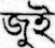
জুই
